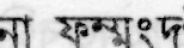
পান্দমসিনা
